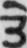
ਤੇ
